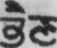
ਭੈਣ
